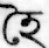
হৈ
